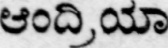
ಆಂದ್ರಿಯಾ
